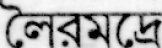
লৈরমদ্রে
